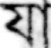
যা
